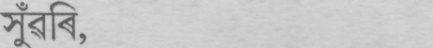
সুঁৱৰি,
